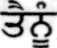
ਤੈਨੂੰ
